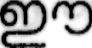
ഈ
